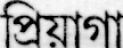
প্রিয়াগা
